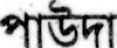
পাউদা
